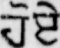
ਹੋਏ
